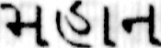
મહાન
